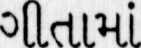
ગીતામાં
